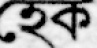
হেক
